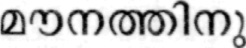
മൌനത്തിനു
